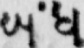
બંધ
